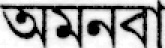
অমনবা
